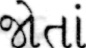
જોતાં
